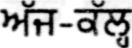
ਅੱਜ-ਕੱਲ੍ਹ
